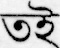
তই
